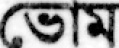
ভোম
